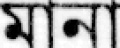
মানা
